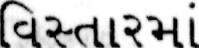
વિસ્તારમાં
